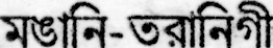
মঙানি-তরানিগী
